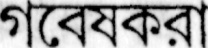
গবেষকরা
